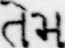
તેમ
